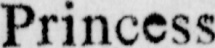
Princess
